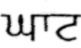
ਘਾਟ
